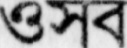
ওসব
